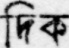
দিক
